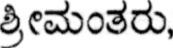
ಶ್ರೀಮಂತರು,
